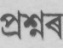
প্ৰশ্নৰ
